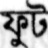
ফুট
